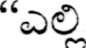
"ಎಲ್ಲಿ
